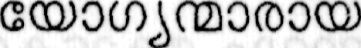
യോഗ്യന്മാരായ
